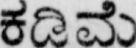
ಕಡಿಮೆ
